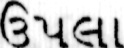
ઉપલા
